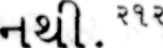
નથી.૨૧૨
